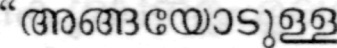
“അങ്ങയോടുള്ള
